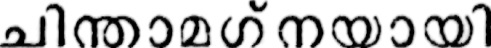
ചിന്താമഗ്നയായി
